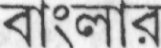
বাংলার
